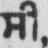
ਸੀ,
